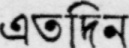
এতদিন
